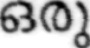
ഒരു
